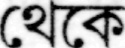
থেকে
